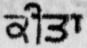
ਕੀਤਾ
